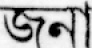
জনা
